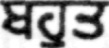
ਬਹੁਤ
